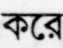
করে
